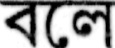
বলে
